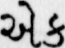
એક
